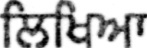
ਲਿਖਿਆ
